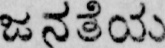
ಜನತೆಯ
